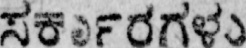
ಸರ್ಕಾರಗಳು
